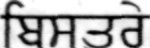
ਬਿਸਤਰੇ
